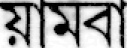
য়ামবা
